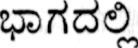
ಭಾಗದಲ್ಲಿ
